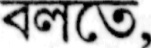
বলতে,
